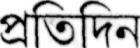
প্রতিদিন
